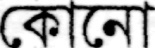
কোনো
